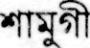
শামুগী
